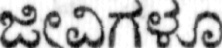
ಜೀವಿಗಳೂ
